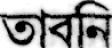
তাবনি
